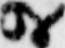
જ
